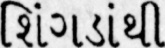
શિંગડાંથી
